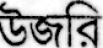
উজরি
